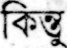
কিন্তু
